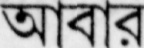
আবার
